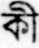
কী
